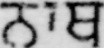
ਨਾਥ
